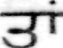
ਤਾਂ
